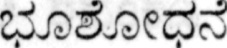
ಭೂಶೋಧನೆ
